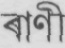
ৰাণী
